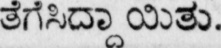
ತೆಗೆಸಿದ್ದಾಯಿತು.
